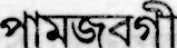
পামজবগী
